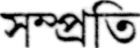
সম্প্রতি
